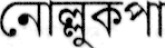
নোল্লুকপা
